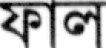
ফাল
